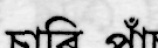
চাৰি
